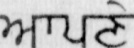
ਆਪਣੇ
